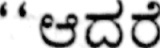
"ಆದರೆ
